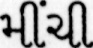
મીંચી
